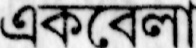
একবেলা
